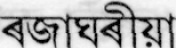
ৰজাঘৰীয়া
